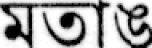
মতাঙ
